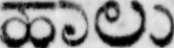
ಹಾಲು
